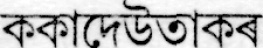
ককাদেউতাকৰ
